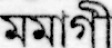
মমাগী
